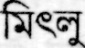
মিৎলু
